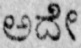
ಅದೇ
